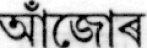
আঁজোৰ
